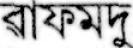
ৱাফমদু
